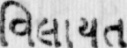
વિલાયત
